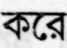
করে
